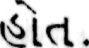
હોત.
